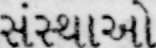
સંસ્થાઓ
